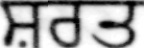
ਸ਼ਰਤ
